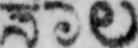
ಸಾಲ
